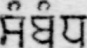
ਸੰਬੰਧ
